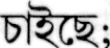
চাইছে;
